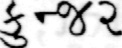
કુન્જર
